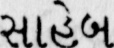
સાહેબ
